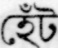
হেঁট
